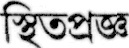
স্থিতপ্রজ্ঞ
